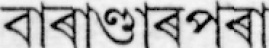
বাৰাণ্ডাৰপৰা
